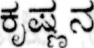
ಕೃಷ್ಣನ
